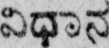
ವಿಧಾನ
